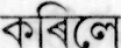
কৰিলে
